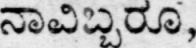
ನಾವಿಬ್ಬರೂ,
